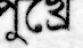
পুখ্রে
